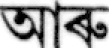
আৰু
